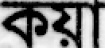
কয়া
